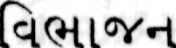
વિભાજન
